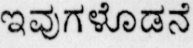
ಇವುಗಳೊಡನೆ
